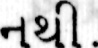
નથી.
